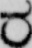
ರ
